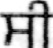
ਸੀ
